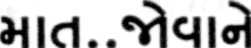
માત...જોવાને
